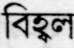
বিহ্বল
